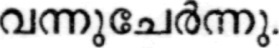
വന്നുചേര്‍ന്നു.
